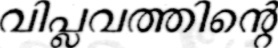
വിപ്ലവത്തിന്റെ
